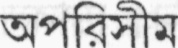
অপরিসীম
